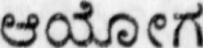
ಆಯೋಗ
